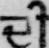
ਦੀ
